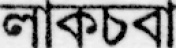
লাকচবা
